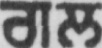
ਗਲ
